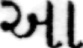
આ
